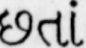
છતાં
